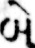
બે
